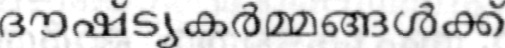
ദൌഷ്ട്യകര്‍മ്മങ്ങള്‍ക്ക്
